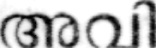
അവി
